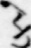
કે
